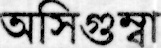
অসিগুম্বা
